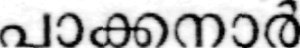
പാക്കനാര്‍
